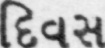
દિવસ
